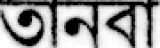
তানবা
